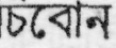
চিবোন
